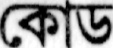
কোড
